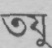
তযু
